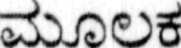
ಮೂಲಕ
